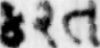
કરતાં
